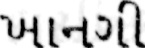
ખાનગી
